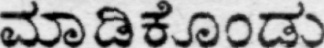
ಮಾಡಿಕೊಂಡು
